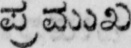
ಪ್ರಮುಖ
